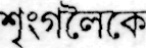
শৃংগলৈকে
